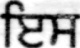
ਇਸ
